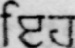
ਇਹ
